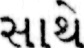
સાથે
